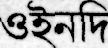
ওইনদি
